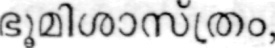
ഭൂമിശാസ്ത്രം,
